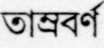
তাম্রবর্ণ
